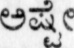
ಅಷ್ಟೇ
